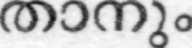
താനും
